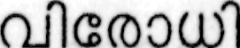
വിരോധി
